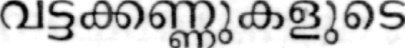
വട്ടക്കണ്ണുകളുടെ
